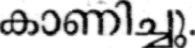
കാണിച്ചു.
